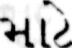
માટે
